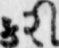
કરી
